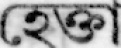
হেক্তা
